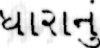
ધારાનું
